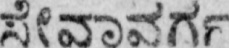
ಸೇವಾವರ್ಗ
